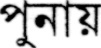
পুনায়
